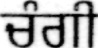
ਚੰਗੀ
